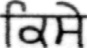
ਕਿਸੇ
